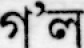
গ'ল
